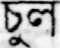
চুল
